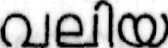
വലിയ
